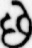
છે
